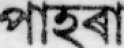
পাহৰা
